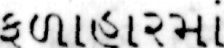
ફળાહારમાં
